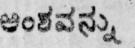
ಅಂಶವನ್ನು
